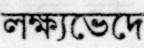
লক্ষ্যভেদে
